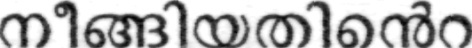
നീങ്ങിയതിന്റെ
